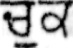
ਚੁਕ
